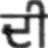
ਦੀ
